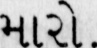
મારો.
